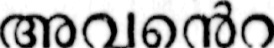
അവന്റെ
